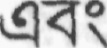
এবং
